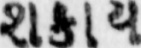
શકાય
